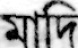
মাদি
